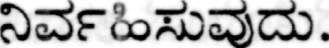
ನಿರ್ವಹಿಸುವುದು.
